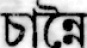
চান্নৈ
